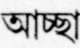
আচ্ছা
